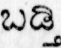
ಬಡ್ತಿ
